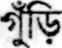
গুঁড়ি
